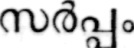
സര്‍പ്പം
